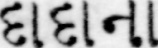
દાદાના
